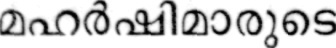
മഹര്‍ഷിമാരുടെ
